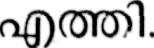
എത്തി.
